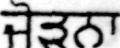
ਜੋੜਨਾ
